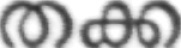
തക്ക
